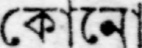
কোনো
